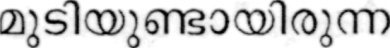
മുടിയുണ്ടായിരുന്ന
